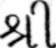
શ્રી
